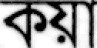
কয়া
